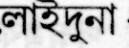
লোইদুনা
